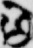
છે
